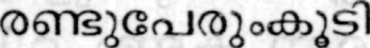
രണ്ടുപേരുംകൂടി
